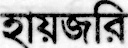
হায়জরি
